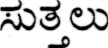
ಸುತ್ತಲು
